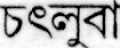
চৎলুবা
